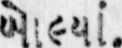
બોલ્યાં.
